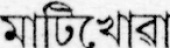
মাটিখোৱা
